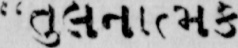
“તુલનાત્મક
